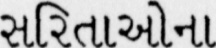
સરિતાઓના
